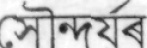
সৌন্দৰ্যৰ
